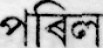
পৰিল
